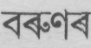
বৰুণৰ
